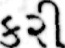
કરી
